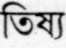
তিষ্য
